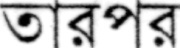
তারপর
